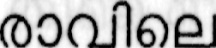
രാവിലെ
